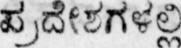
ಪ್ರದೇಶಗಳಲ್ಲಿ
